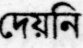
দেয়নি
